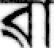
ৱা
